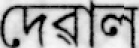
দেৱাল
